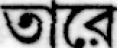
তারে
